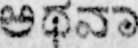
ಅಥವಾ
